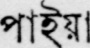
পাইয়া
